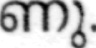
ണു.
